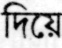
দিয়ে
